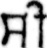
ਸੀ
